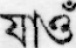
যাওঁ
